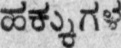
ಹಕ್ಕುಗಳ
